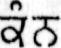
ਕੰਨ
